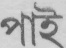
পাই
